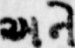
અને
